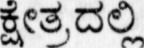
ಕ್ಷೇತ್ರದಲ್ಲಿ
